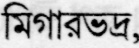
মিগারভদ্র,
